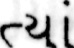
ત્યાં
